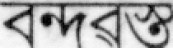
বন্দৱস্ত
